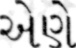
એણે
